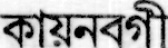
কায়নবগী
